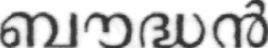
ബൌദ്ധന്‍
